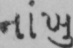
નાંખુ
